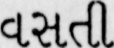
વસતી
